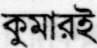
কুমারই
